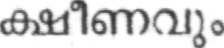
ക്ഷീണവും
